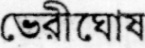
ভেরীঘোষ
